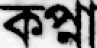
কপ্না
